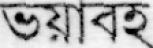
ভয়াবহ
